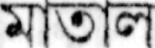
মাতাল
